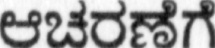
ಆಚರಣೆಗೆ
